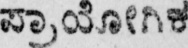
ಪ್ರಾಯೋಗಿಕ
